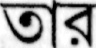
তার
